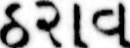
ઠરાવ
